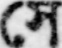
সে
